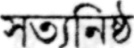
সত্যনিষ্ঠ
